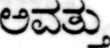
ಅವತ್ತು
